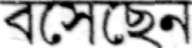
বসেছেন
